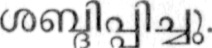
ശബ്ദിപ്പിച്ചു.
